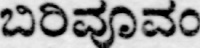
ಬಿರಿವೂವ೦
